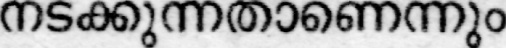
നടക്കുന്നതാണെന്നും
